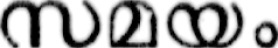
സമയം
